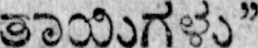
ತಾಯಿಗಳು”
